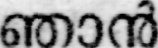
ഞാന്‍
